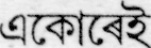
একোৰেই
